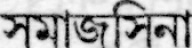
সমাজসিনা
